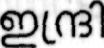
ഇന്ദ്രി
